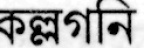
কল্লগনি
